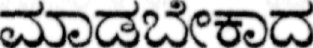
ಮಾಡಬೇಕಾದ
